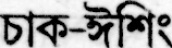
চাক-ঈশিং
